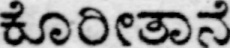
ಕೊರೀತಾನೆ.
